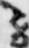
કે
